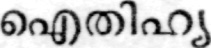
ഐതിഹ്യ
